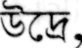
উদ্রে,
